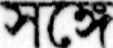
সঙ্গে
